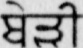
ਬੇੜੀ
